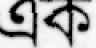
এক
